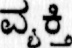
ವ್ಯಕ್ತಿ
